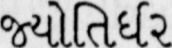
જ્યોતિર્ધર
